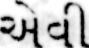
એવી
